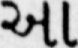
આ
